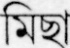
মিছা
